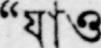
‘‘যাও
